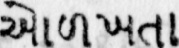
ઓળખતા
